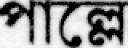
পাল্লে
